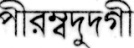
পীরম্বদুদগী
